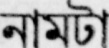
নামটা
